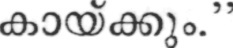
കായ്ക്കും."
